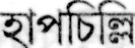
হাপচিল্লি
